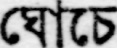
ঘোচে
